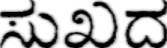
ಸುಖದ
